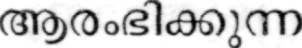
ആരംഭിക്കുന്ന
